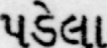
પડેલા
